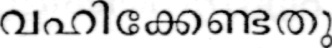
വഹിക്കേണ്ടതു
